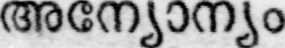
അന്യോന്യം
